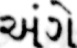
અંગે
